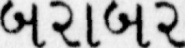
બરાબર
